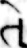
તે
